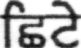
ਛਿਟੇ
